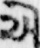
એ
